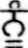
ਨੂੰ
